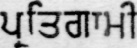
ਪ੍ਰਤਿਗਾਮੀ
